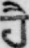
ਹੈ
